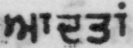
ਆਦਤਾਂ
